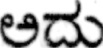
ಅದು
